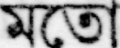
মতো
